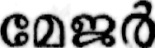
മേജര്‍
